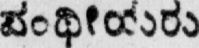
ಪಂಥೀಯರು
